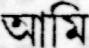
আমি
